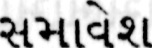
સમાવેશ
